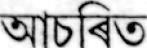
আচৰিত
